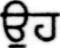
ਉਹ
